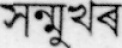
সন্মুখৰ
